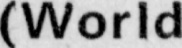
(World
